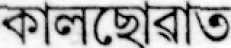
কালছোৱাত
